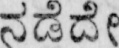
ನಡೆದೇ
